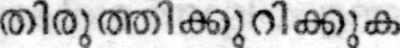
തിരുത്തിക്കുറിക്കുക
